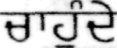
ਚਾਹੁੰਦੇ
